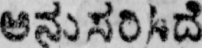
ಅನುಸರಿಸಿದೆ
